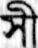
সী
